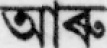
আৰু
